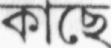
কাছে
